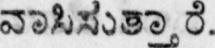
ವಾಸಿಸುತ್ತಾರೆ.
